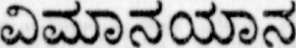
ವಿಮಾನಯಾನ
